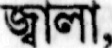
জ্বালা,
